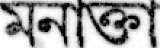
মনাক্তা
